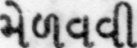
મેળવવી
